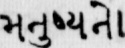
મનુષ્યનો
